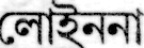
লোইননা
